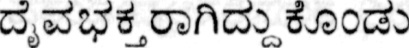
ದೈವಭಕ್ತರಾಗಿದ್ದುಕೊಂಡು
